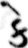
કે
